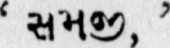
'સમજી,'
